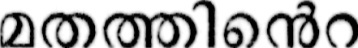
മതത്തിന്റെ
